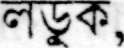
লডুক,
